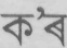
ক'ৰ
